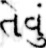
તેવું
